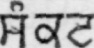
ਸੰਕਟ
